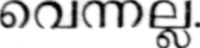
വെന്നല്ല.
